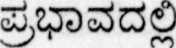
ಪ್ರಭಾವದಲ್ಲಿ
